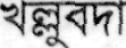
খল্লুবদা
